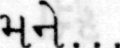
મને...
